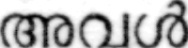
അവള്‍
